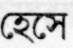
হেসে
